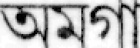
অমগা
